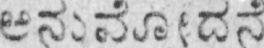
ಅನುಮೋದನೆ
